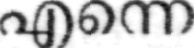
എന്നെ
